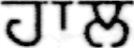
ਹਾਲ
